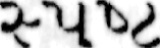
સ્પષ્ટ
